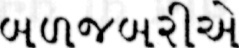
બળજબરીએ
